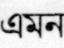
এমন
